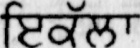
ਇਕੱਲਾ
